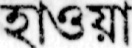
হাওয়া
